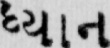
ધ્યાન
